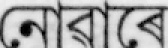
নোৱাৰে
